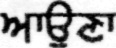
ਆਉਣਾ
